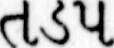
તડપ
